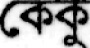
কেকু
